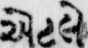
એટલે
